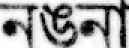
নঙনা
